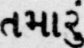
તમારું
